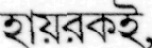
হাযরকই,
